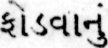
ફોડવાનું
